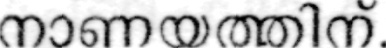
നാണയത്തിന്.
